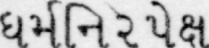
ધર્મનિરપેક્ષ
